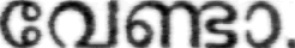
വേണ്ടാ.
